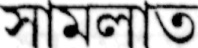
সামলাত
